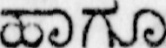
ಹಾಗೂ
